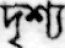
দৃশ্য
